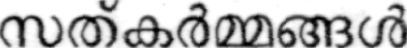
സത്കര്‍മ്മങ്ങള്‍
